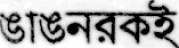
ঙাঙনরকই
